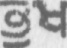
ਭੁਖ
